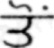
ਤੋਂ
